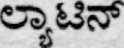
ಲ್ಯಾಟಿನ್
